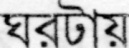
ঘরটায়
